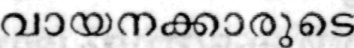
വായനക്കാരുടെ
